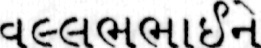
વલ્લભભાઈને
